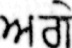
ਅਗੇ
